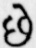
છે
